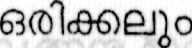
ഒരിക്കലും
